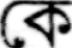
কে
